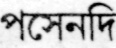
পসেনদি
